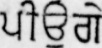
ਪੀਉਗੇ
